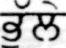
ਭੁੱਲੇ
